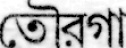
তৌরগা
